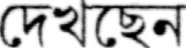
দেখছেন
